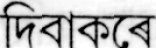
দিবাকৰে
